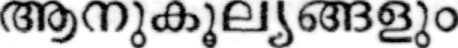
ആനുകൂല്യങ്ങളും
